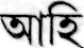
আহি
